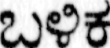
ಬಳಿಕ
